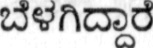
ಬೆಳಗಿದ್ದಾರೆ
